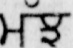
ਮੱਝ
